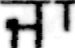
ਜਾ
